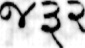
જરૂર
